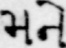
મને
